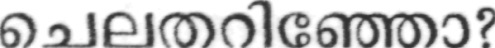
ചെലതറിഞ്ഞോ?
